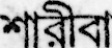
শারীবা
